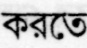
করতে
